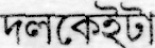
দলকেইটা
